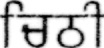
ਚਿਠੀ
